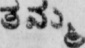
ತಮ್ಮ
